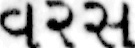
વરસ
